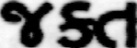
જક્ત
